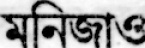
মনিজাও
